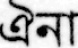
ঐনা
